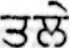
ਤਲੇ
